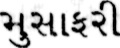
મુસાફરી
